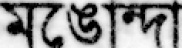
মঙোন্দা
